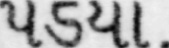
પડ્યા.
